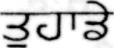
ਤੁਹਾਡੇ
